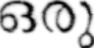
ഒരു
